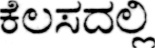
ಕೆಲಸದಲ್ಲಿ
